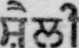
ਸ਼ੈਲੀ
